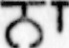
ਨਾ
